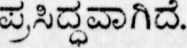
ಪ್ರಸಿದ್ಧವಾಗಿದೆ.
